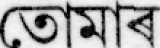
তোমাৰ
